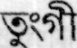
তুংগী
